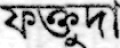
ফক্তুদা
